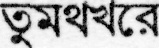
তুমথখরে
